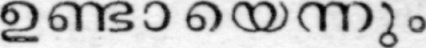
ഉണ്ടായെന്നും
